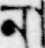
না
